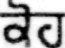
ਕੋਹ
